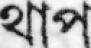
থাপ
